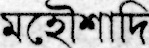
মহৌশাদি
